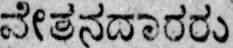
ವೇತನದಾರರು
